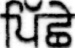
ਪਿੱਛੇ
